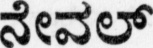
ನೇವಲ್
